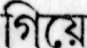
গিয়ে
